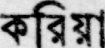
করিয়া
